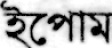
ইপোম
